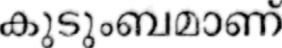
കുടുംബമാണ്
